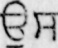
ਉਸ
